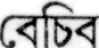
বেচিব
